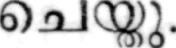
ചെയ്തു.
